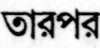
তারপর
